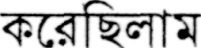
করেছিলাম
